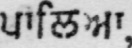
ਪਾਲਿਆ,
